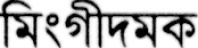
মিংগীদমক
